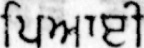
ਪਿਆਈ
